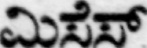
ಮಿಸೆಸ್
